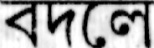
বদলে
